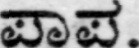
ಪಾಪ.
